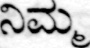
ನಿಮ್ಮ
